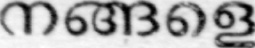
നങ്ങളെ
